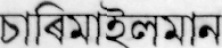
চাৰিমাইলমান
